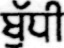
ਬੁੱਧੀ
